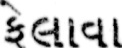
ફેલાવા
